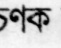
চণক
